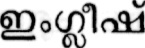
ഇംഗ്ലീഷ്
